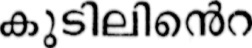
കുടിലിന്റെ
